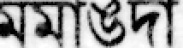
মমাঙদা
